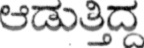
ಆಡುತ್ತಿದ್ದ
